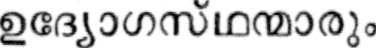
ഉദ്യോഗസ്ഥന്മാരും
